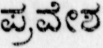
ಪ್ರವೇಶ
